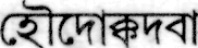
হৌদোক্কদবা
